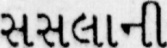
સસલાની
